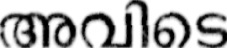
അവിടെ
